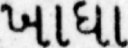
ખાધા
